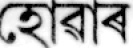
হোৱাৰ
